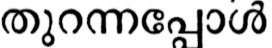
തുറന്നപ്പോള്‍
